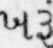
ખરૂં
